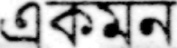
একমন
